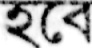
হবে
